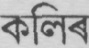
কলিৰ
